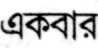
একবার
